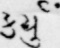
કર્યું
